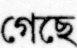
গেছে
